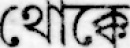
থোক্কে
